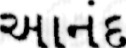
આનંદ
